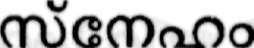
സ്നേഹം
